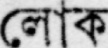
লোক
